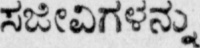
ಸಜೀವಿಗಳನ್ನು
